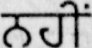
ਨਹੀਂ
